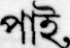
পাই,
